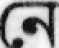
নে
